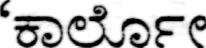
‘ಕಾರ್ಲೋ
